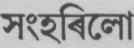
সংহৰিলো
